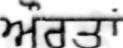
ਔਰਤਾਂ
